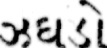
ઝઘડો
